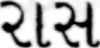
રાસ
